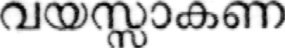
വയസ്സാകണ
